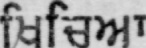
ਖਿਚਿਆ
